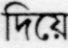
দিয়ে
